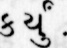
કર્યું.
